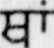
ਥਾਂ
